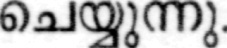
ചെയ്യുന്നു.
